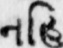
નહિ.
